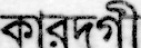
কারদগী
